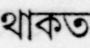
থাকত
